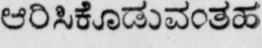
ಆರಿಸಿಕೊಡುವಂತಹ
